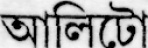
আলিটো
